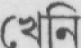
খেনি
